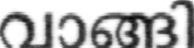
വാങ്ങി
